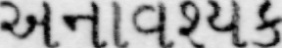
અનાવશ્યક
